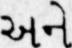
અને
